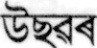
উছৱৰ
